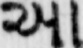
આ
